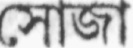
সোজা
